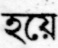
হয়ে
